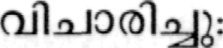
വിചാരിച്ചു:
